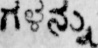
ಗಳನ್ನು
